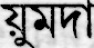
য়ুমদা
